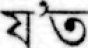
য'ত
